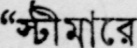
‘‘স্টীমারে
